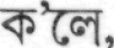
ক'লে,
